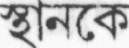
স্থানকে
